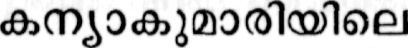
കന്യാകുമാരിയിലെ
